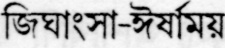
জিঘাংসা-ঈর্ষাময়
